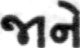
જાને
